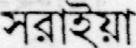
সরাইয়া
